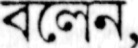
বলেন,
